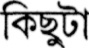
কিছুটা
